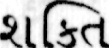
શક્તિ
